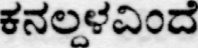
ಕನಲ್ದಳವಿಂದೆ
